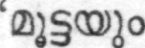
‘മൂട്ടയും
